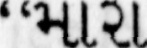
"મારા
